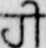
ਹੀ
